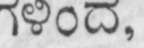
ಗಳಿಂದ,
